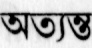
অত্যন্ত
